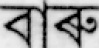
বাৰু
